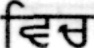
ਵਿਚ
